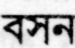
বসন
